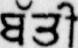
ਬੱਤੀ
